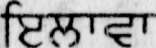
ਇਲਾਵਾ
